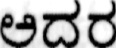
ಅದರ
